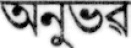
অনুভৱ
